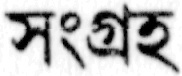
সংগ্রহ
